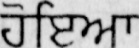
ਹੋਇਆ
